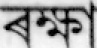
ৰক্ষা
